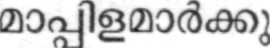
മാപ്പിളമാര്‍ക്കു
